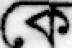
কে
